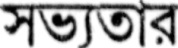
সভ্যতার
